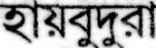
হায়বুদুরা
